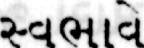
સ્વભાવે
